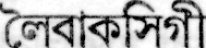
লৈবাকসসিগী
